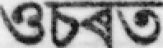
ওচৰত
